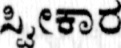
ಸ್ವೀಕಾರ
